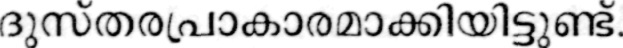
ദുസ്തരപ്രകാരമാക്കിയിട്ടുണ്ട്.
